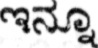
ಇನ್ನೂ
